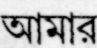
আমার
